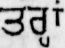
ਤਰ੍ਹਾਂ
